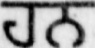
ਹਨ
